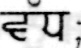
ਵੱਧ;
